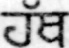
ਹੱਥ
